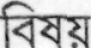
বিষয়
